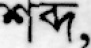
শব্দ,
